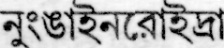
নুংঙাইনরোইদ্রা
